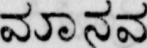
ಮಾನವ
